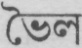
ভৈল
